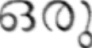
ഒരു
